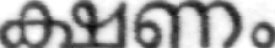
ക്ഷണം
